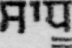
ਸਾਧੂ
